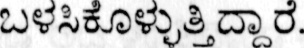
ಬಳಸಿಕೊಳ್ಳುತ್ತಿದ್ದಾರೆ.
